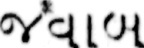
જવાબ
